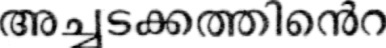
അച്ചടക്കത്തിന്റെ
